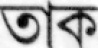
তাক
